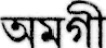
অমগী
